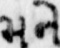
મને
